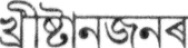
খ্ৰীষ্টানজনৰ
